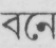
বনে
